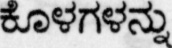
ಕೊಳಗಳನ್ನು
